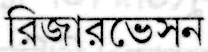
রিজারভেসন
